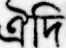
ঐদি
